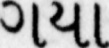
ગયા
